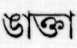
ঙাক্তা
